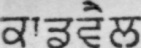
ਕਾਡਵੈਲ
